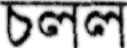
চলল
